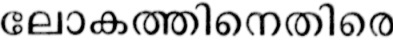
ലോകത്തിനെതിരെ
